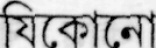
যিকোনো
